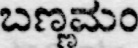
ಬಣ್ಣಮಂ
